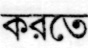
করতে
